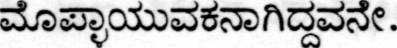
ಮೊಪ್ಳಾಯುವಕನಾಗಿದ್ದವನೇ.
